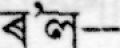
ৰ'ল-
